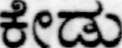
ಕೇಡು
